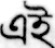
এই
